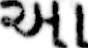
આ
